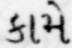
કામે
